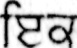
ਇਕ
